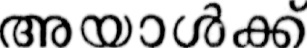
അയാള്‍ക്ക്
